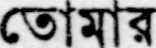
তোমার
